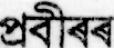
প্রবীৰৰ
